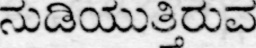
ನುಡಿಯುತ್ತಿರುವ
